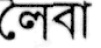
লৈবা
